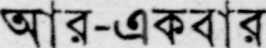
আর-একবার
